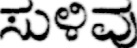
ಸುಳಿವು
